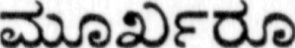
ಮೂರ್ಖರೂ
